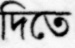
দিতে
